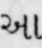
આ
